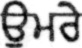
ਉਮਰੇ
